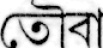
তৌবা
